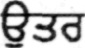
ਉਤਰ
